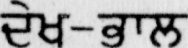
ਦੇਖ-ਭਾਲ
